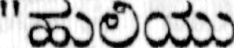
“ಹುಲಿಯು
